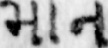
માન
